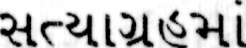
સત્યાગ્રહમાં
